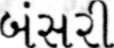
બંસરી
